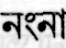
নংনা
